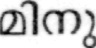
മിനു
